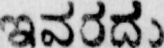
ಇವರದು
